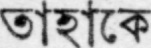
তাহাকে
